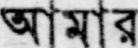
আমার
